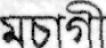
মচাগী
